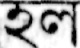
হল
